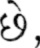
છે,
